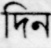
দিন
